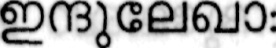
ഇന്ദുലേഖാ:
